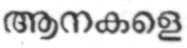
ആനകളെ
